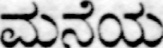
ಮನೆಯ
